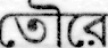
তৌরে
